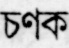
চণক
